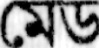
মেড
